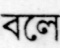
বলে
